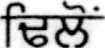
ਢਿਲੋਂ
